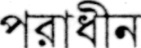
পরাধীন
